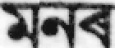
মনৰ
